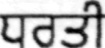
ਧਰਤੀ
